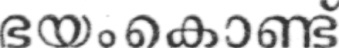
ഭയംകൊണ്ട്
